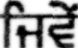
ਜਿਵੇਂ
